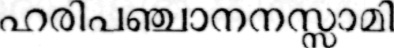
ഹരിപഞ്ചാനനസ്സാമി
